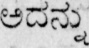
ಅದನ್ನು
